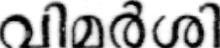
വിമര്‍ശി
